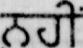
ਨਹੀਂ
